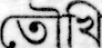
তৌখি
